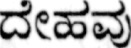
ದೇಹವು
